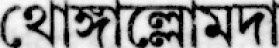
থোঙ্গাল্লোমদা
